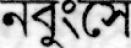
নবুংসে
